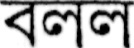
বলল
